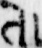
તો
